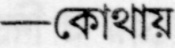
–কোথায়
